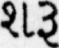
શરૂ
